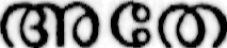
അതേ
